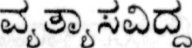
ವ್ಯತ್ಯಾಸವಿದ್ದ
